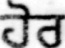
ਹੋਰ
